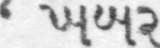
'ખબર
